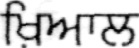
ਖ਼ਿਆਲ
